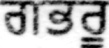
ਗਭਰੂ
